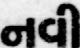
નવી
